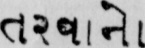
તરવાનો
